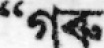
"গৰু
